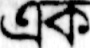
এক
